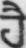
ਹੈ
